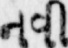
નવી
